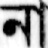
না
